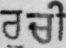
ਰੁਚੀ
